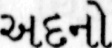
અદનો
